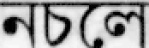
নচলে
